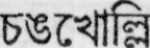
চঙখোল্লি
